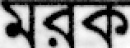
মরক
